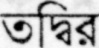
তদ্বির
